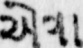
એવા
